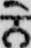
ਨੇ
